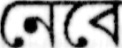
নেবে
